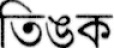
তিঙক
